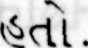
હતો.
